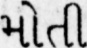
મોતી
